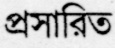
প্রসারিত
